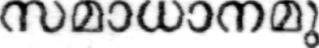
സമാധാനമു
